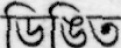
ডিঙিত
